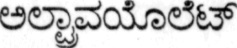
ಅಲ್ಟ್ರಾವಯೊಲೆಟ್
